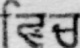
ਵਿਚ
